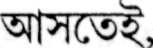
আসতেই,
